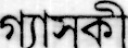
গ্যাসকী
